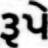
રૂપે
